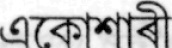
একোশাৰী
